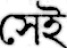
সেই
